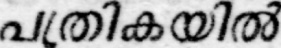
പത്രികയില്‍
